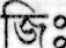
জিঃ
